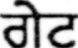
ਗੇਟ
